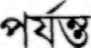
পর্যন্ত
